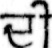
ਦੀ
